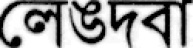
লেঙদবা
